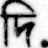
দি.
